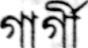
গার্গী
